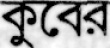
কুবের
